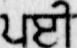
ਪਈ
